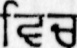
ਵਿਚ
